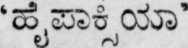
‘ಹೈಪಾಕ್ಸಿಯಾ’
